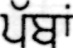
ਪੱਬਾਂ
